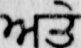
ਅਤੇ
